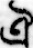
ঐ
